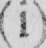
(i)
